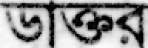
ডাক্তর
